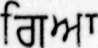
ਗਿਆ
